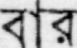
বার
